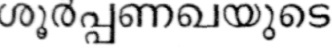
ശൂര്‍പ്പണഖയുടെ
